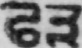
ਫੜ
